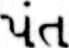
પંત
